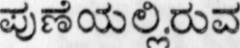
ಪುಣೆಯಲ್ಲಿರುವ
